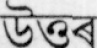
উত্তৰ
